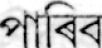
পাৰিব
